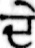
ਦੇ
